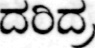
ದರಿದ್ರ
